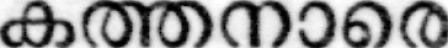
കത്തനാരെ
